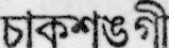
চাকশঙগী
